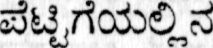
ಪೆಟ್ಟಿಗೆಯಲ್ಲಿನ
